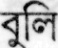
বুলি
